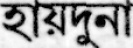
হায়দুনা
